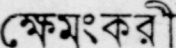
ক্ষেমংকরী
